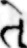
તે
